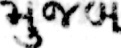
મુજબ
